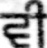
ਵੀ
